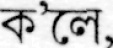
ক'লে,
